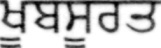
ਖੂਬਸੂਰਤ
